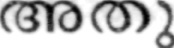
അതു
